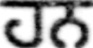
ਹਨ
